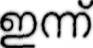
ഇന്ന്
